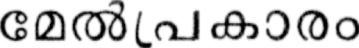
മേല്‍പ്രകാരം
